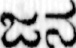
ಜನ
